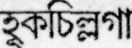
হূকচিল্লগা
